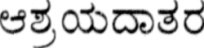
ಆಶ್ರಯದಾತರ
